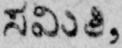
ಸಮಿತಿ,
